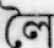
লৈ
